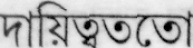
দায়িত্বততো
